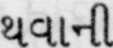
થવાની
